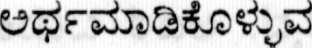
ಅರ್ಥಮಾಡಿಕೊಳ್ಳುವ
